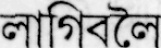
লাগিবলৈ
